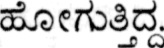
ಹೋಗುತ್ತಿದ್ದ.
